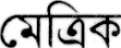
মেত্রিক
